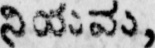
ನಿಯಮ,
